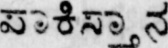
ಪಾಕಿಸ್ತಾನ
